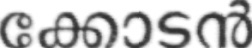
ക്കോടന്‍
